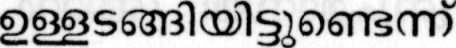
ഉള്ളടങ്ങിയിട്ടുണ്ടെന്ന്
